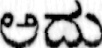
ಅದು
